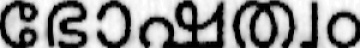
ഭോഷത്വം
